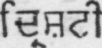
ਦ੍ਰਿਸ਼ਟੀ
